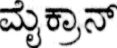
ಮೈಕ್ರಾನ್
